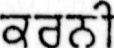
ਕਰਨੀ
